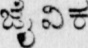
ಜೈವಿಕ
